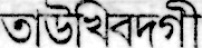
তাউখিবদগী
